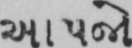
આપજો
